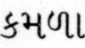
કમળા
